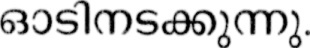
ഓടിനടക്കുന്നു.
